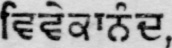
ਵਿਵੇਕਾਨੰਦ,
